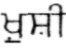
ਖ਼ੁਸ਼ੀ
